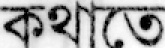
কথাতে
